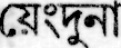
য়েংদুনা
